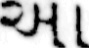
આ
